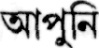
আপুনি
